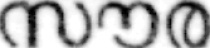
സൌര
